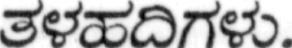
ತಳಹದಿಗಳು.
